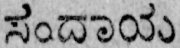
ಸಂದಾಯ
